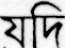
যদি
